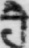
ਹੈ
